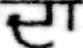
ਦਾ
